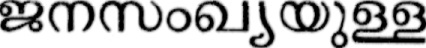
ജനസംഖ്യയുള്ള
